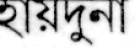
হায়দুনা
